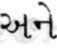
અને
